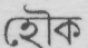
হৌকে
